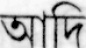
আদি
